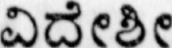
ವಿದೇಶೀ
